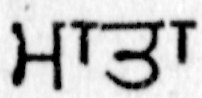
ਮਾਤਾ
